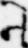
ને
